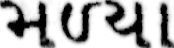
મળ્યા
